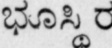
ಭೂಸ್ಥಿರ
